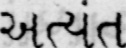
અત્યંત
